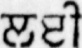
ਲਈ
